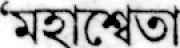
'মহাশ্বেতা
